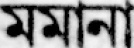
মমানা
